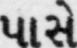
પાસે
